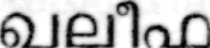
ഖലീഫ
